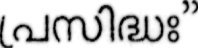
പ്രസിദ്ധഃ"
